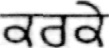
ਕਰਕੇ
